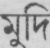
মুদি
